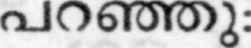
പറഞ്ഞു:
